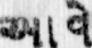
આવે
